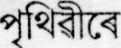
পৃথিৱীৰে
